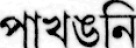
পাখঙনি
